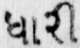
ધારી
